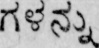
ಗಳನ್ನು
